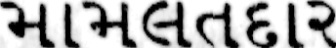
મામલતદાર
